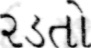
રડતો
